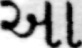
આ
